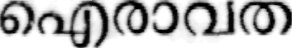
ഐരാവത
